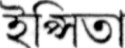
ইপ্সিতা
